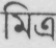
মিত্ৰ
